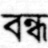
বন্ধ
